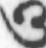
ও
